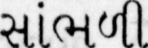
સાંભળી
